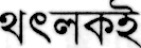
থৎলকই
